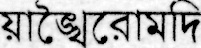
য়াঙ্খৈরোমদি
